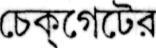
চেক্গেটের
